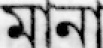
মানা
